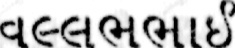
વલ્લભભાઈ
